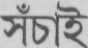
সঁচাই
